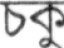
চকু
